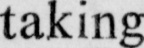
taking
